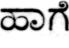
ಹಾಗೆ
